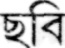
ছবি
